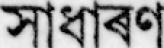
সাধাৰণ
